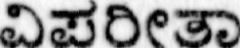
ವಿಪರೀತಾ
